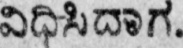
ವಿಧಿಸಿದಾಗ.
